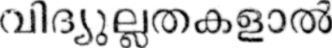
വിദ്യുല്ലതകളാല്‍
